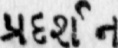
પ્રદર્શન
